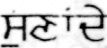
ਸੁਣਾਂਦੇ
